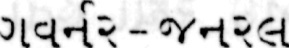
ગવર્નર-જનરલ
